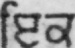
ਇਕ
